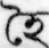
হৈ
